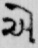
એ
